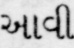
આવી
